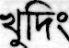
খুদিং
